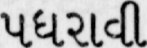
પધરાવી
